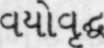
વયોવૃદ્ધ
